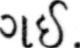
ગઈ.
